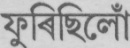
ফুৰিছিলোঁ
